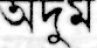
অদুম
